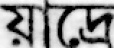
য়াদ্রে
